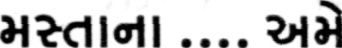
મસ્તાના....અમે
